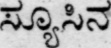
ಸ್ಯೂಸಿನ
